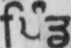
ਪਿੰਡ
